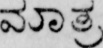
ಮಾತ್ರ
